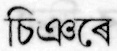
চিঞৰে
